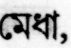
মেধা,
